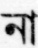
না
